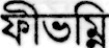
ফীভম্নি
